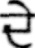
ਦੇ
